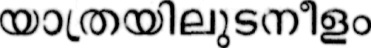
യാത്രയിലുടനീളം
